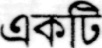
একটি
